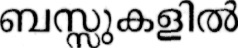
ബസ്സുകളില്‍
